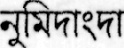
নুমিদাংদা
